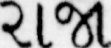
રાજા
